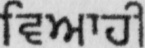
ਵਿਆਹੀ
